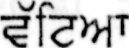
ਵੱਟਿਆ
